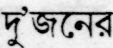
দু’জনের
